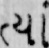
ત્યાં
